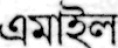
এমাইল
